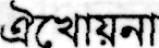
ঐখোয়না
